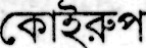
কোইরুপ
